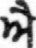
ਐ
